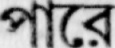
পারে
